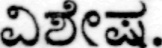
ವಿಶೇಷ.
